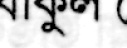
বোকুল
